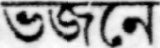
ভজনে
